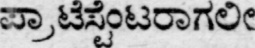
ಪ್ರಾಟೆಸ್ಟೆ೦ಟರಾಗಲೀ
